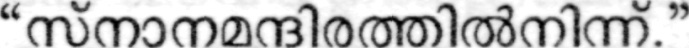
"സനാനമന്ദിരത്തില്‍നിന്ന്.”
